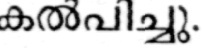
കല്‍പിച്ചു.
